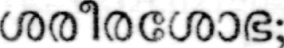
ശരീരശോഭ;
